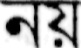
নয়
